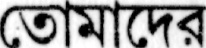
তোমাদের
